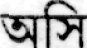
অসি
